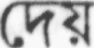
দেয়
